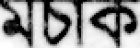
মচাক
